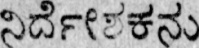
ನಿರ್ದೇಶಕನು
